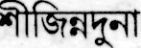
শীজিন্নদুনা
